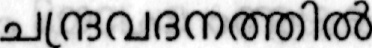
ചന്ദ്രവദനത്തില്‍
